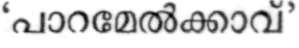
‘പാറമേല്‍ക്കാവ്’
